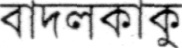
বাদলকাকু
